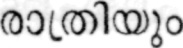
രാത്രിയും
